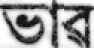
ভাৱ
